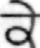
ਕੇ
